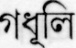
গধূলি
